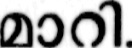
മാറി.
